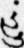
હું
